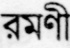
রমণী
